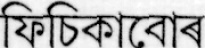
ফিচিকাবোৰ
